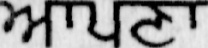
ਆਪਣਾ
